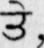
ਤੇ,
